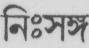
নিঃসঙ্গ
